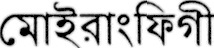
মোইরাংফিগী
